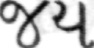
જય
